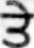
ਤੇ
